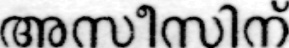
അസീസിന്
